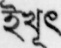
ইখূৎ
